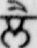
ਲੈ
